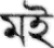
মই
